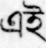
এই
